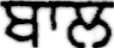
ਬਾਲ
